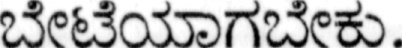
ಬೇಟೆಯಾಗಬೇಕು.
